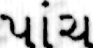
પાંચ
